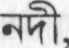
নদী,
